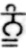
ਨੂੰ
